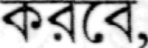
করবে,
